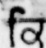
ਕਿ
